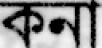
কনা
